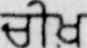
ਚੀਖ਼
